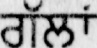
ਗੱਲਾਂ
